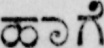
ಹಾಗೆ
